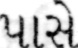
પાસે
